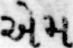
એમ
